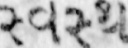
સ્વસ્થ
